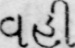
વહી
